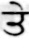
ਤੇ
